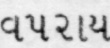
વપરાય
